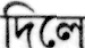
দিলে
